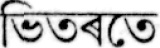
ভিতৰতে
